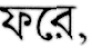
ফরে,
